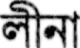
লীনা
